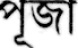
পূজা
